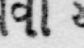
એવી
